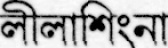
লীলাশিংনা
